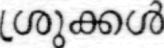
ശ്രുക്കള്‍
